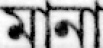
মানা
